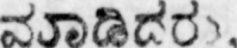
ಮಾಡಿದರು.
